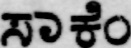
ಸಾಕೆಂ
